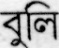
বুলি
